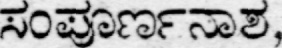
ಸಂಪೂರ್ಣನಾಶ,
